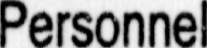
Personnel
